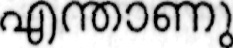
എന്താണു
